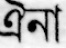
ঐনা
